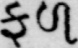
ફળ
